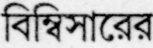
বিম্বিসারের
